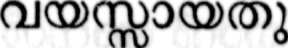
വയസ്സായതു
